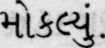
મોકલ્યું.
